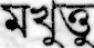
মখুত্তু
